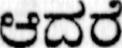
ಆದರೆ
